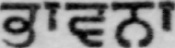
ਭਾਵਨਾ
